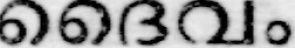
ദൈവം
